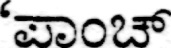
‘ಪಾಂಚ್
